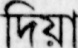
দিয়া
